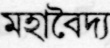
মহাবৈদ্য
